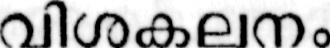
വിശകലനം
